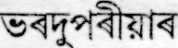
ভৰদুপৰীয়াৰ
